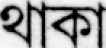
থাকা
